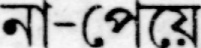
না-পেয়ে
